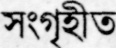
সংগৃহীত
